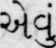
એવું
